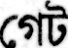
গেট
